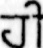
ਹੀ
